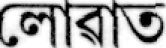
লোৱাত
